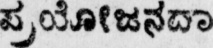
ಪ್ರಯೋಜನದಾ
